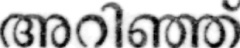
അറിഞ്ഞ്
